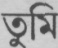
তুমি
